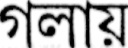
গলায়
